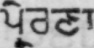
ਪ੍ਰੇਰਣਾ
